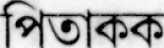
পিতাকক
